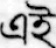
এই
